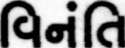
વિનંતિ
